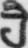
ਹੈ
